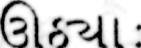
ઊઠ્યાઃ
